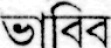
ভাবিব
